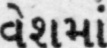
વેશમાં
